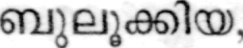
ബുലൂക്കിയ,
